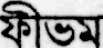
ফীভম
